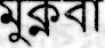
মুক্নবা
